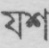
যশ
